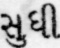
સુધી
